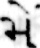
મેં
